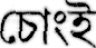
চোংই
